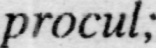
procul;
